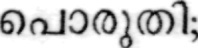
പൊരുതി;
